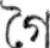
গৈ
